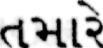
તમારે
